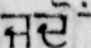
ਜਦੋਂ
